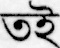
তই
